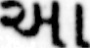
આ
